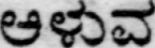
ಅಳುವ
